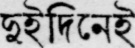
দুইদিনেই
